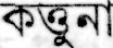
কত্তুনা
